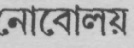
নোবোলয়
